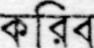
করিব
